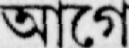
আগে
